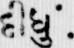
દીધું.
